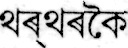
থৰ্‌থৰকৈ
